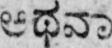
ಅಥವಾ
